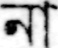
না
